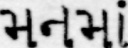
મનમાં
